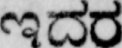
ಇದರ
